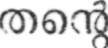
തന്റെ
